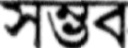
সম্ভব
